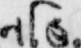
નહિ.
